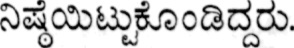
ನಿಷ್ಠೆಯಿಟ್ಟುಕೊಂಡಿದ್ದರು.
